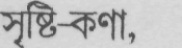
সৃষ্টি-কণা,
